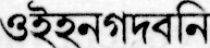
ওইহনগদবনি
